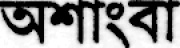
অশাংবা
